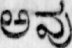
ಅವು
